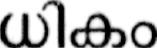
ധികം
